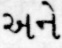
અને
